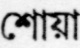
শোয়া
